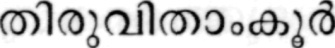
തിരുവിതാംകൂര്‍
